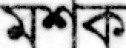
মশক
